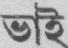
ভাই
